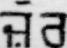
ਜ਼ੋਰ
